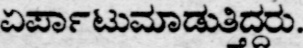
ಏರ್ಪಾಟುಮಾಡುತ್ತಿದ್ದರು.
